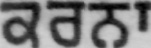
ਕਰਨਾ
